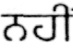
ਨਹੀਂ
